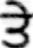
ਤੇ
